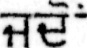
ਜਦੋਂ
